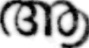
ആ
